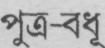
পুত্ৰ-বধূ
